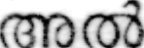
അല്‍
